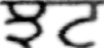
ਝਟ
